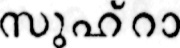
സുഹ്റാ
